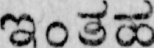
ಇಂತಹ
